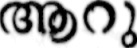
ആറു
